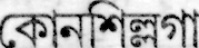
কোনশিল্লগা
